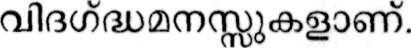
വിദഗ്ദ്ധമനസ്സുകളാണ്.
